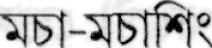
মচা-মচাশিং
